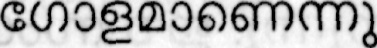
ഗോളമാണെന്നു
